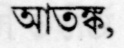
আতঙ্ক,
